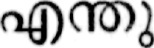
എന്തു
